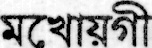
মখোয়গী
